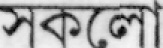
সকলো
